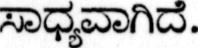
ಸಾಧ್ಯವಾಗಿದೆ.
